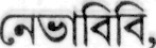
নেভাবিবি,
